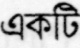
একটি
